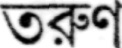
তরুণ
